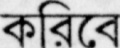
করিবে
